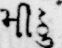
મીઠું
